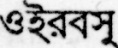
ওইরবসু
